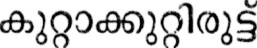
കുറ്റാക്കുറ്റിരുട്ട്
